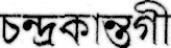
চন্দ্রকান্তগী
